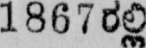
1867ರಲ್ಲಿ
